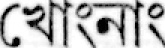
খোংনাং
